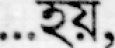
...হয়,
